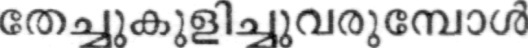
തേച്ചുകുളിച്ചുവരുമ്പോള്‍
